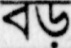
বড়
